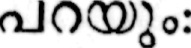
പറയും:
